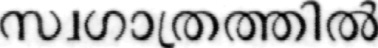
സ്വഗാത്രത്തില്‍
